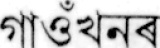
গাওঁখনৰ
